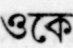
ওকে
